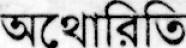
অথোরিতি
